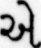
એ
